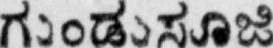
ಗುಂಡುಸೂಜಿ
